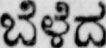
ಬೆಳೆದ
